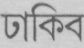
ঢাকিব
